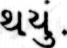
થયું.
